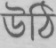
উঠি
